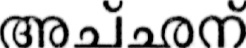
അച്ഛന്
